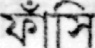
ফাঁসি
